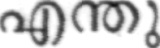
എന്തു
